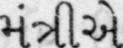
મંત્રીએ
